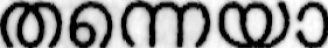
തന്നെയാ
